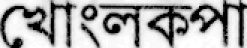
খোংলকপা
